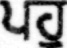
ਪਹੁ
